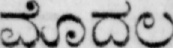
ಮೊದಲ
